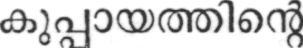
കുപ്പായത്തിന്റെ
